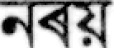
নৰয়
